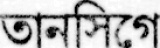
তানসিগে
